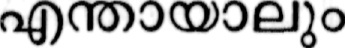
എന്തായാലും
